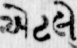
એટલે
